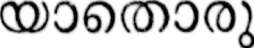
യാതൊരു
